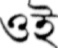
ওই
